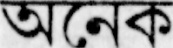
অনেক
